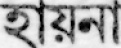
হায়না
